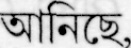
আনিছে,
